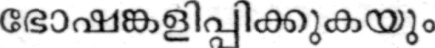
ഭോഷങ്കളിപ്പിക്കുകയും
